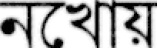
নখোয়
